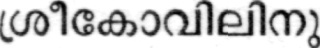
ശ്രീകോവിലിനു
